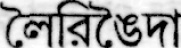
লৈরিঙৈদা
